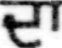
ਦਾ
